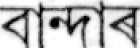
বান্দাৰ
